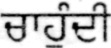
ਚਾਹੁੰਦੀ
